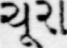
ચૂરા
